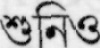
শুনিও
